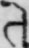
તે
